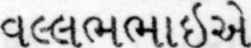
વલ્લભભાઈએ
